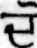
ਦੋ
